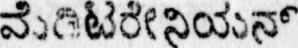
ಮೆಡಿಟರೇನಿಯನ್
